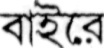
বাইরে
